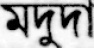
মদুদা
